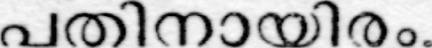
പതിനായിരം.
